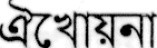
ঐখোয়না
